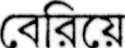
বেরিয়ে
